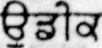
ਉਡੀਕ
